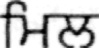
ਮਿਲ
